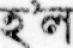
হ'ল
